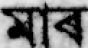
মাৰ
